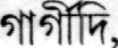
গার্গীদি,
